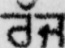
ਰੱਜ
